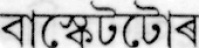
বাস্কেটটোৰ
